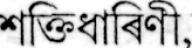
শক্তিধাৰিণী,
